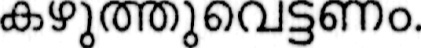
കഴുത്തുവെട്ടണം.
